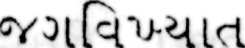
જગવિખ્યાત
